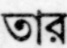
তার
